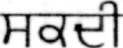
ਸਕਦੀ
